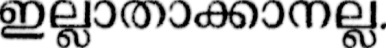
ഇല്ലാതാക്കാനല്ല.
